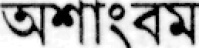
অশাংবম
